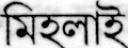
মিহলাই
